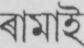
ৰামাই
